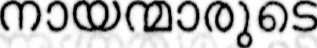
നായന്മാരുടെ
